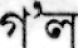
গ'ল
